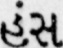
હંસ
